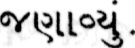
જણાવ્યું.
